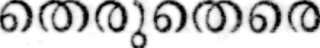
തെരുതെരെ
